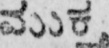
ಮುಕ್ತ
